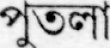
পুতলা
